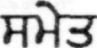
ਸਮੇਤ
